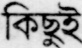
কিছুই
